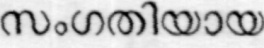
സംഗതിയായ
